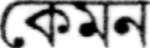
কেমন
